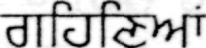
ਗਹਿਣਿਆਂ
